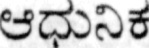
ಆಧುನಿಕ
